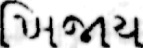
ખિજાય
